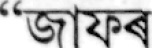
"জাফৰ
